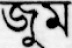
জুম
